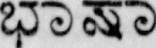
ಭಾಷಾ
